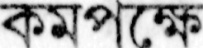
কমপক্ষে
